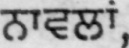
ਨਾਵਲਾਂ,
